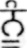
ਨੂੰ
